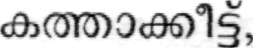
കത്താക്കീട്ട്,
